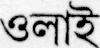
ওলাই
